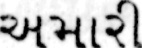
અમારી
